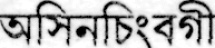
অসিনচিংবগী
